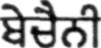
ਬੇਚੈਨੀ
